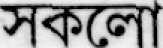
সকলো
